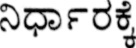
ನಿರ್ಧಾರಕ್ಕೆ
